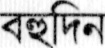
বহুদিন
